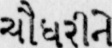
ચૌધરીને
